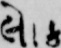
લોક
